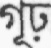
গূঢ়
